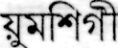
য়ুমশিগী
